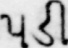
પડી
